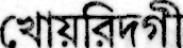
খোয়রিদগী
